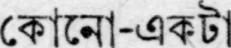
কোনো-একটা
